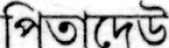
পিতাদেউ
